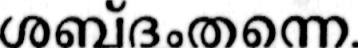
ശബ്ദംതന്നെ.
